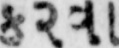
કરવા
